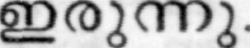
ഇരുന്നു.
